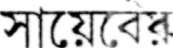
সায়েবের
